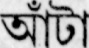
আঁটা
